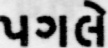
પગલે
